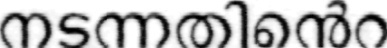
നടന്നതിന്റെ
